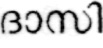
ദാസി
